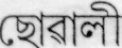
ছোৱালী
